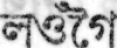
লওঁগৈ
